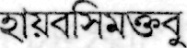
হায়বসিমক্তবু
